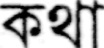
কথা
